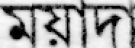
ময়াদা
